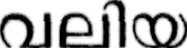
വലിയ
